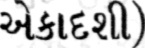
એકાદશી)
